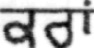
ਕਰਾਂ
